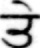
ਤੇ
